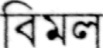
বিমল
